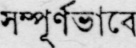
সম্পূর্ণভাবে
